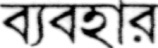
ব্যবহার
